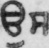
ਉਸ
